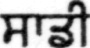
ਸਾਡੀ
